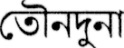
তৌনদুনা
